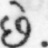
છે.
